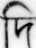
দি
